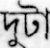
দুটা
